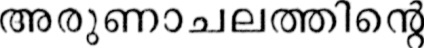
അരുണാചലത്തിന്റെ
